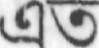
এত
